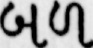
બળ
